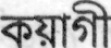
কয়াগী
